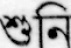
শুনি
